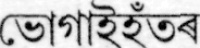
ভোগাইহঁতৰ
